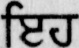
ਇਹ
